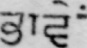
ਭਾਵੇਂ
